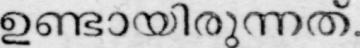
ഉണ്ടായിരുന്നത്.
